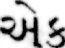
એક
